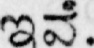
ಇವೆ.
